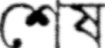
শেষ
